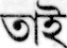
তাই
